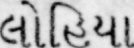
લોહિયા
